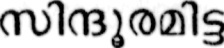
സിന്ദൂരമിട്ട
